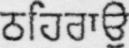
ਠਹਿਰਾਉ
